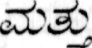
ಮತ್ತು
